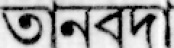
তানবদা
